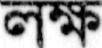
লক্ষ
